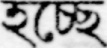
হচ্ছে
